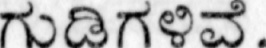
ಗುಡಿಗಳಿವೆ.
